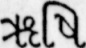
ઋષિ
